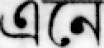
এনে
